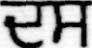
ਦਸ
